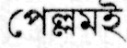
পেল্লমই
